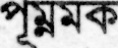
পূম্নমক
